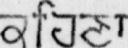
ਕਹਿਣਾ
